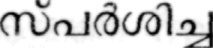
സ്പര്‍ശിച്ച
